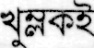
খুম্লকই
